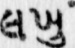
લખું
